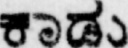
ಕಾಡು
